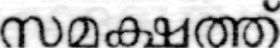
സമക്ഷത്ത്
